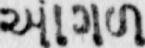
આગળ
